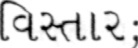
વિસ્તાર;
